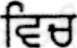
ਵਿਚ
